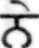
ਨੇ
